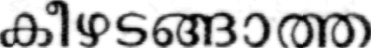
കീഴടങ്ങാത്ത
